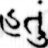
હતું
